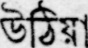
উঠিয়া
